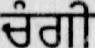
ਚੰਗੀ
